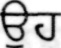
ਉਹ
